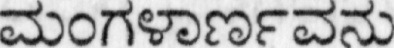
ಮಂಗಳಾರ್ಣವನು
